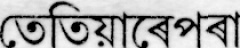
তেতিয়াৰেপৰা
